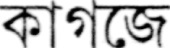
কাগজে
